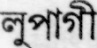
লুপাগী
